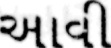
આવી
